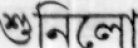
শুনিলো
